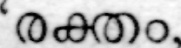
'രക്തം,
